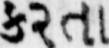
કરતા
